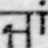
ਜਾਂ
